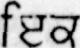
ਇਕ
